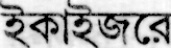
ইকাইজরে
